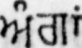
ਅੰਗਾਂ
